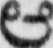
ಆ
